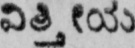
ವಿತ್ತೀಯ
